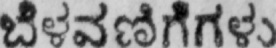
ಬೆಳವಣಿಗೆಗಳು
